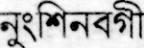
নুংশিনবগী
